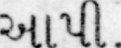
આપી.
